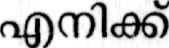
എനിക്ക്
